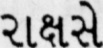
રાક્ષસે
